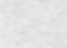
જ
